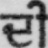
ਦੀ
